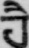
ਹੈ
